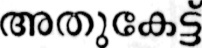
അതുകേട്ട്
